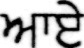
ਆਏ
